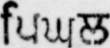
ਪਿਘਲ
